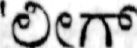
‘ಲೀಗ್
